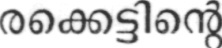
രക്കെട്ടിന്റെ
